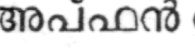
അപ്ഫന്‍
